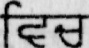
ਵਿਚ
